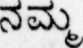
ನಮ್ಮ
